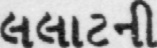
લલાટની
